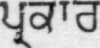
ਪ੍ਰਕਾਰ
